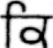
ਕਿ
